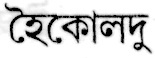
হৈকোলদু
